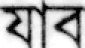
যাব
